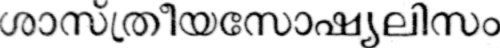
ശാസ്ത്രീയസോഷ്യലിസം
